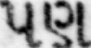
પણ
